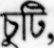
চুটি,
